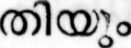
തിയും
